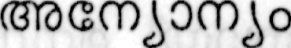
അന്യോന്യം
